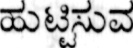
ಹುಟ್ಟಿಸುವ
